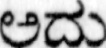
ಅದು
